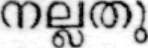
നല്ലതു
